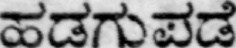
ಹಡಗುಪಡೆ
